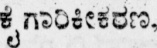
ಕೈಗಾರಿಕೀಕರಣ,
